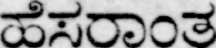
ಹೆಸರಾಂತ
